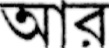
আর
